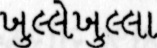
ખુલ્લેખુલ્લા
